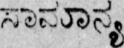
ಸಾಮಾನ್ಯ
